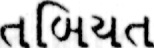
તબિયત
